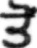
ਤੋਂ
